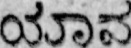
ಯಾವ
